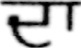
ਦਾ
